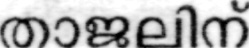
താജലിന്
